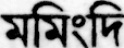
মমিংদি
